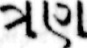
ત્રણ
